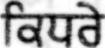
ਕਿਧਰੇ
